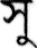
সু
